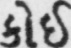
કોઈ
